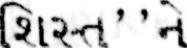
શિસ્ત"ને
